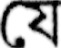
যে
